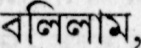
বলিলাম,
